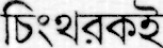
চিংথরকই
